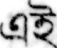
এই
